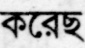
করেছ
